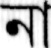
না
